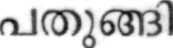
പതുങ്ങി
